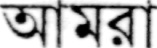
আমরা
